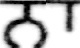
ਨਾ
